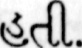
હતી.
